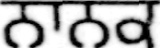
ਨਾਨਕ
